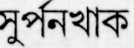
সুর্পনখাক
